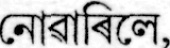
নোৱাৰিলে,
